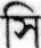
সি
